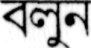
বলুন
